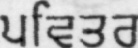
ਪਵਿਤਰ
